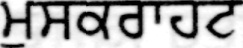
ਮੁਸਕਰਾਹਟ
